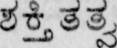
ಶಕ್ತಿತತ್ವ
